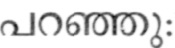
പറഞ്ഞു:
